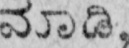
ಮಾಡಿ,
